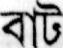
বাট
